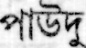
পাউদু
